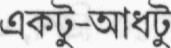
একটু-আধটু
